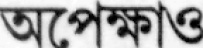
অপেক্ষাও
